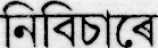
নিবিচাৰে
